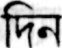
দিন
